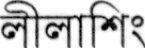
লীলাশিং
